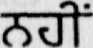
ਨਹੀਂ
